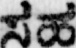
ಸಹ
